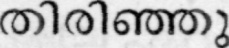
തിരിഞ്ഞു
